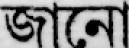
জানো
